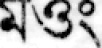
মওং
